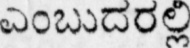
ಎಂಬುದರಲ್ಲಿ
